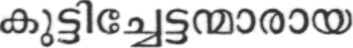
കുട്ടിച്ചേട്ടന്മാരായ
